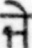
ਜੇ
